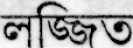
লজ্জিত
